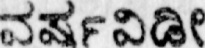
ವರ್ಷವಿಡೀ
